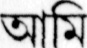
আমি
